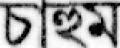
চাহুম
